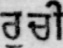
ਰੁਚੀ
